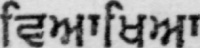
ਵਿਆਖਿਆ
